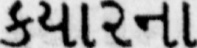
કયારના
